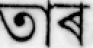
তাৰ
